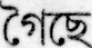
গৈছে
